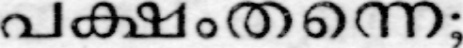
പക്ഷംതന്നെ;
